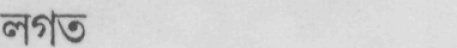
লগত
